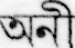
অনী
